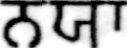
ਨਯਾ
